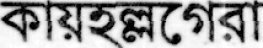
কায়হল্লগেরা
